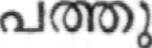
പത്തു
